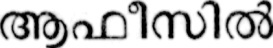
ആഫീസില്‍
